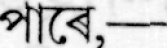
পাৰে,-
